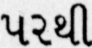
પરથી
